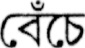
বেঁচে
